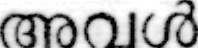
അവള്‍
